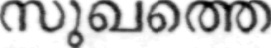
സുഖത്തെ
